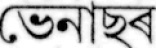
ভেনাছৰ
